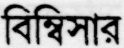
বিম্বিসার
